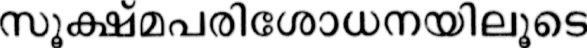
സൂക്ഷ്മപരിശോധനയിലൂടെ
